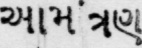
આમંત્રણ
